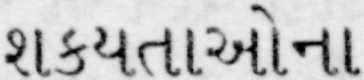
શક્યતાઓના
